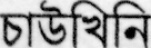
চাউখিনি
